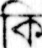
কি
